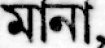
মানা,
